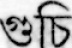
গুচি
